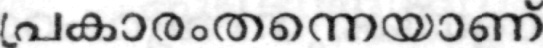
പ്രകാരംതന്നെയാണ്
